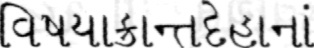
વિષયાક્રાન્તદેહાનાં
